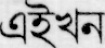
এইখন
